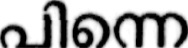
പിന്നെ
